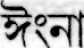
ঈংনা
